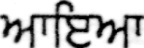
ਆਇਆ
